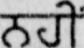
ਨਹੀਂ
